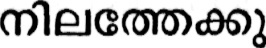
നിലത്തേക്കു
